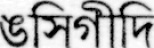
ঙসিগীদি
